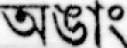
অঙাং
